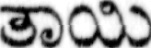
ತಾಯಿ
